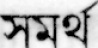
সমর্থ
